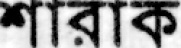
শারাক
